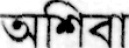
অশিবা
